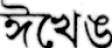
ঈখেঙ
